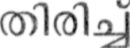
തിരിച്ച്
